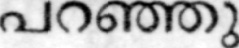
പറഞ്ഞു
